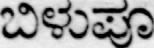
ಬಿಳುಪೂ
